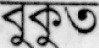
বুকুত
